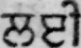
ਲਈ
